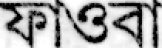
ফাওবা
